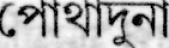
পোথাদুনা
